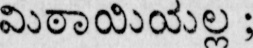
ಮಿಠಾಯಿಯಲ್ಲ;
